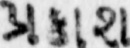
પ્રકાશ
